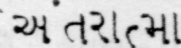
અંતરાત્મા
